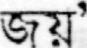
জয়’
